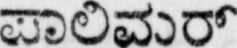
ಪಾಲಿಮರ್
